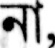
না,
